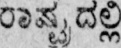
ರಾಷ್ಟ್ರದಲ್ಲಿ
